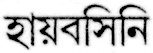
হায়বসিনি
